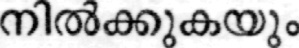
നില്‍ക്കുകയും
